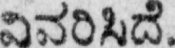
ವಿವರಿಸಿದೆ.
